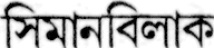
সিমানবিলাক
